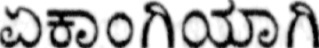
ಏಕಾಂಗಿಯಾಗಿ
